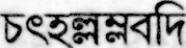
চৎহল্লম্লবদি
